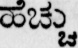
ಹೆಚ್ಚು
